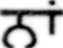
ਨਾਂ
